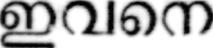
ഇവനെ
